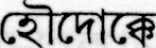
হৌদোক্কে
